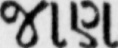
જાણ
